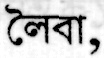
লৈবা,
